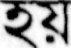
হয়
